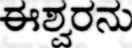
ಈಶ್ವರನು
